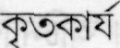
কৃতকার্য
